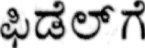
ಫಿಡೆಲ್ಗೆ
